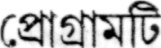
প্রোগ্রামটি
